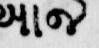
આજે
